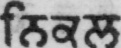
ਨਿਕਲ
